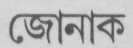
জোনাক
